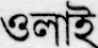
ওলাই
